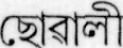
ছোৱালী
